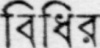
বিধির
